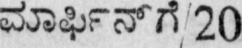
ಮಾರ್ಫಿನ್‌ಗೆ/20
